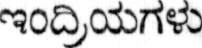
ಇಂದ್ರಿಯಗಳು
